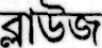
ব্লাউজ
